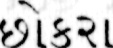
છોકરા
